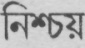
নিশ্চয়
